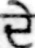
ਦੇ
